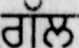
ਗੱਲ
